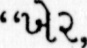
"ખેર,
